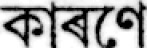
কাৰণে
